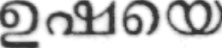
ഉഷയെ
